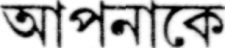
আপনাকে
